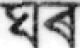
ঘৰ
